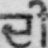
ਦੀ
